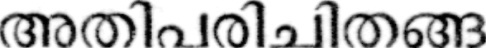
അതിപരിചിതങ്ങ
